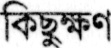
কিছুক্ষণ
